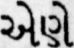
એણે
